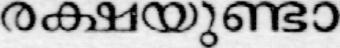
രക്ഷയുണ്ടാ
